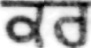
ਕਰ
